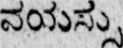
ವಯಸ್ಸು
